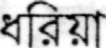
ধরিয়া
